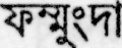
ফম্মুংদা
